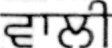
ਵਾਲੀ
